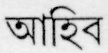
আহিব
